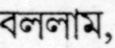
বললাম,
